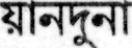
য়ানদুনা
